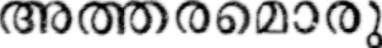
അത്തരമൊരു
